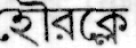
হৌরক্লে
